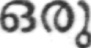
ഒരു
